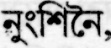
নুংশিনৈ,
